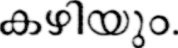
കഴിയും.
